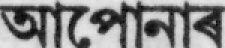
আপোনাৰ
